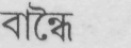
বান্ধৈ
